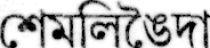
শেমলিঙৈদা
